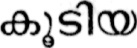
കൂടിയ
